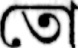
তো
